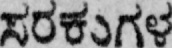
ಸರಕುಗಳ
